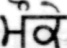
ਮੌਕੇ
